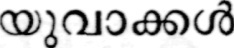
യുവാക്കള്‍
